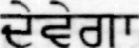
ਦੇਵੇਗਾ
